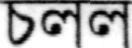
চলল
